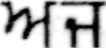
ਅਜ
